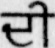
ਦੀ
